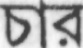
চার
